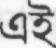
এই
